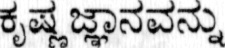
ಕೃಷ್ಣಜ್ಞಾನವನ್ನು
